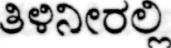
ತಿಳಿನೀರಲ್ಲಿ
